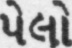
પેલો
